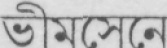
ভীমসেনে
